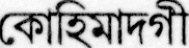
কোহিমাদগী
